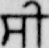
ਸੀ
